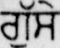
ਗੁੱਸੇ
